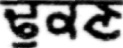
ਢੁਕਣ
